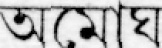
অমোঘ
